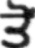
ਤੋਂ
